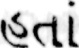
હતાં
